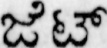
ಜೆಟ್
